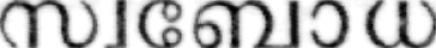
സ്വബോധ
